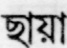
ছায়া
